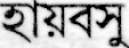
হায়বসু
